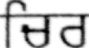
ਚਿਰ
